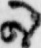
જે
